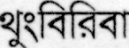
থুংবিরিবা
